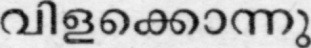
വിളക്കൊന്നു
